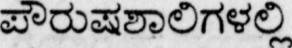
ಪೌರುಷಶಾಲಿಗಳಲ್ಲಿ
